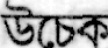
উচেক
